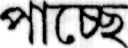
পাচ্ছে
